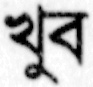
খুব
